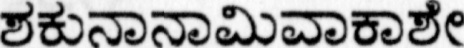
ಶಕುನಾನಾಮಿವಾಕಾಶೇ
